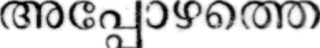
അപ്പോഴത്തെ
